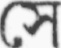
সে
